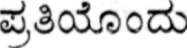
ಪ್ರತಿಯೊಂದು
